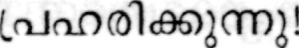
പ്രഹരിക്കുന്നു!
